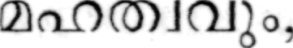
മഹത്വവും,
